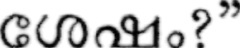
ശേഷം?"
